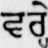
ਵਰ੍ਹੇ
